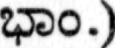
ಭಾಂ.)
